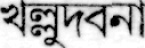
খল্লুদবনা
